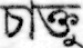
চাক্তু
